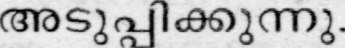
അടുപ്പിക്കുന്നു.
